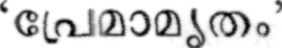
‘പ്രേമാമൃതം'
